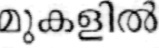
മുകളില്‍
